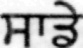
ਸਾਡੇ
